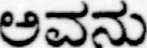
ಅವನು
